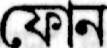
ফোন
